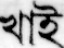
খাই
